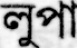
লুপা
